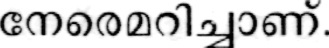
നേരെമറിച്ചാണ്.
